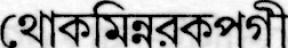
থোকমিন্নরকপগী
